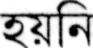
হয়নি
